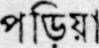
পড়িয়া
